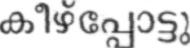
കീഴ്പ്പോട്ടു
